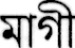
মাগী
